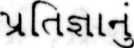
પ્રતિજ્ઞાનું
